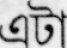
এটা
